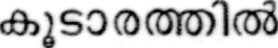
കൂടാരത്തില്‍
